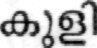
കുളി
